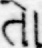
તો
